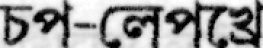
চপ-লেপখ্রে
